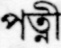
পত্নী
